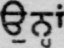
ਉਨ੍ਹਾਂ
